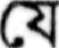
যে
